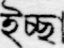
ইচ্ছা
